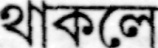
থাকলে
